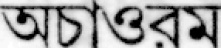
অচাওরম
